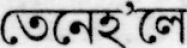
তেনেহ'লে
